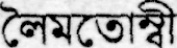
লৈমতোম্বী
